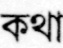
কথা
